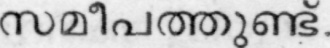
സമീപത്തുണ്ട്.
